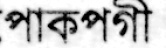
পোকপগী
